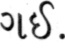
ગઈ.
